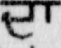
ਦਾ
